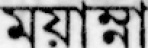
ময়াম্না
